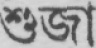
শুজা
